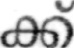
ക്ക്
